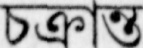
চক্রান্ত
